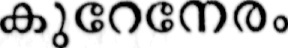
കുറേനേരം
